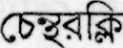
চেন্থরক্লি
